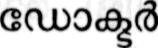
ഡോക്ടര്‍
